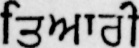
ਤਿਆਰੀ
